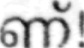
ണ്!
